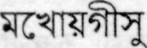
মখোয়গীসু
